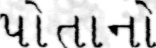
પોતાનો
